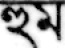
হুম
